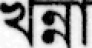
খন্না
